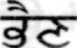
ਭੈਣ
